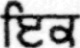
ਇਕ
